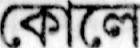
কোলে
